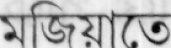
মজিয়াতে
